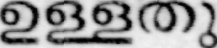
ഉള്ളതു
